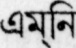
এম্‌নি
